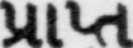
પ્રાપ્ત
